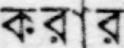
করার
